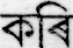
কৰি
